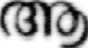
ആ
